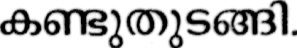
കണ്ടുതുടങ്ങി.
